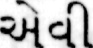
એવી
